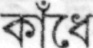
কাঁধে
